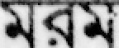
মরম
